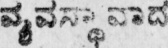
ವ್ಯವಸ್ಥಾವಾದ
